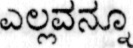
ಎಲ್ಲವನ್ನೂ
